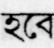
হবে
